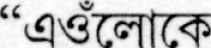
"এওঁলোকে
